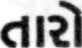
તારો
